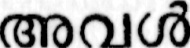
അവള്‍
